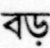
বড়
